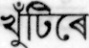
খুঁটিৰে
